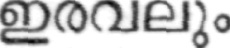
ഇരവലും
